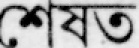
শেষত
